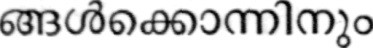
ങ്ങള്‍ക്കൊന്നിനും
